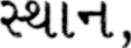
સ્થાન,
